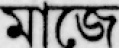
মাজে
